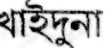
খাইদুনা
